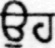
ਉਹ
